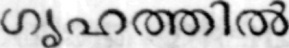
ഗൃഹത്തില്‍
